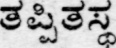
ತಪ್ಪಿತಸ್ಥ
